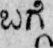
ಬಗ್ಗೆ
